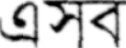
এসব
